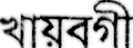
খায়বগী
